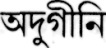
অদুগীনি
